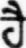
ਹੈ
